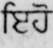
ਇਹੋ
